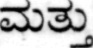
ಮತ್ತು
